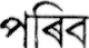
পৰিব
